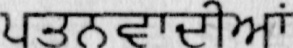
ਪਤਨਵਾਦੀਆਂ
